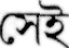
সেই
